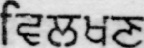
ਵਿਲਖਣ
